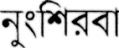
নুংশিরবা
